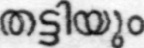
തട്ടിയും
